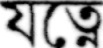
যত্নে
